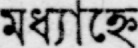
মধ্যাহ্নে
